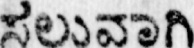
ಸಲುವಾಗಿ
